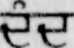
ਦੰਦ
